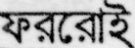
ফররোই
